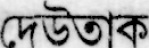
দেউতাক
